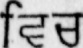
ਵਿਚ
